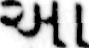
આ
